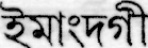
ইমাংদগী
